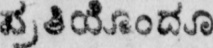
ಪ್ರತಿಯೊಂದೂ
